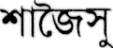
শাজৈসু
